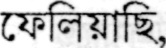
ফেলিয়াছি,
